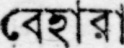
বেহারা
